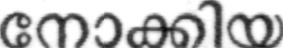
നോക്കിയ
